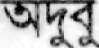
অদুবু
